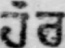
ਹੋਰ
